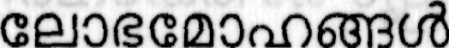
ലോഭമോഹങ്ങള്‍
